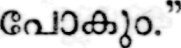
പോകും.”
